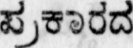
ಪ್ರಕಾರದ
